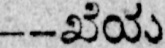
--ಖೆಯ
